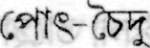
পোৎ-চৈ
